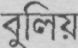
বুলিয়
